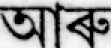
আৰু
